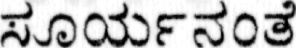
ಸೂರ್ಯನಂತೆ
